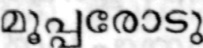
മൂപ്പരോടു
